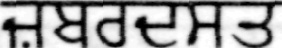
ਜ਼ਬਰਦਸਤ
